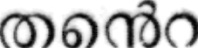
തന്റെ
